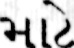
માટે
